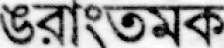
ঙরাংতমক
